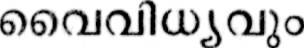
വൈവിധ്യവും
